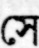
সে
